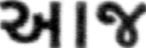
આજ
